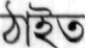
ঠাইত
